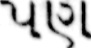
પણ
